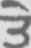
ਤੇ
